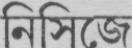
নিসিজে
